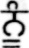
ਨੂੰ
